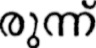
രുന്ന്
